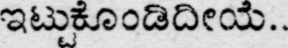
ಇಟ್ಟುಕೊಂಡಿದೀಯೆ..
